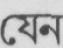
যেন
